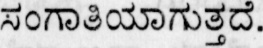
ಸಂಗಾತಿಯಾಗುತ್ತದೆ.
